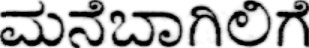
ಮನೆಬಾಗಿಲಿಗೆ
